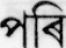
পৰি
